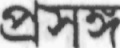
প্রসঙ্গ
